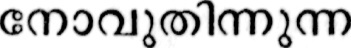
നോവുതിന്നുന്ന
